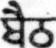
ਬੈਠ
